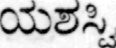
ಯಶಸ್ವಿ
